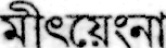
মীৎয়েংনা
